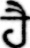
ਹੈ
